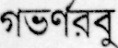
গভর্ণরবু
